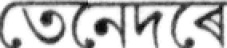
তেনেদৰে
